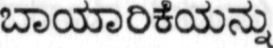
ಬಾಯಾರಿಕೆಯನ್ನು
